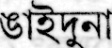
ঙাইদুনা
